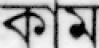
কাম
